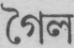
গৈল
